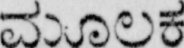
ಮೂಲಕ
